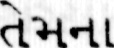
તેમના
